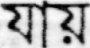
যায়
